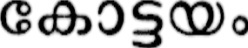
കോട്ടയം
